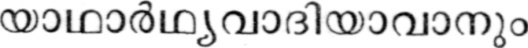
യാഥാര്‍ഥ്യവാദിയാവാനും
